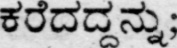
ಕರೆದದ್ದನ್ನು;
